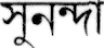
সুনন্দা
